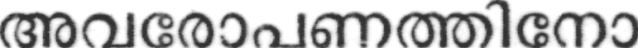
അവരോപണത്തിനോ
